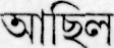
আছিল
